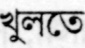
খুলতে
